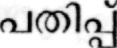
പതിപ്പ്
